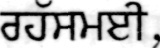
ਰਹੱਸਮਈ,
